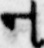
ન
